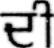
ਦੀ
